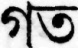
গত
